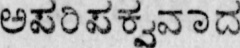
ಅಪರಿಪಕ್ವವಾದ
